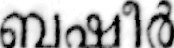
ബഷീര്‍
